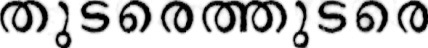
തുടരെത്തുടരെ
